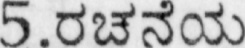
5.ರಚನೆಯ
